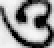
ও
